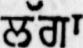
ਲੱਗਾ
